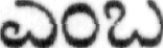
ಎಂಬ
